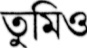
তুমিও
